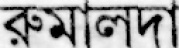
রুমালদা
